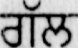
ਗੱਲ
